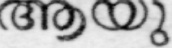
ആയു
